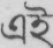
এই
